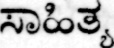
ಸಾಹಿತ್ಯ
